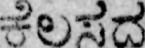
ಕೆಲಸದ
